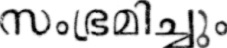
സംഭ്രമിച്ചും
